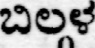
ಬಿಲ್ಗಳ
